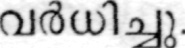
വര്‍ധിച്ചു.
